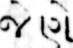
જેણે
